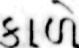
કાળે
